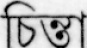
চিন্তা
